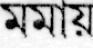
মমায়
